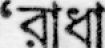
‘রাধা
